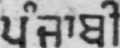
ਪੰਜਾਬੀ
